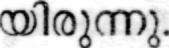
യിരുന്നു.
